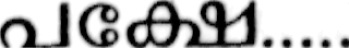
പക്ഷേ....
